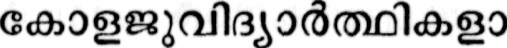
കോളജുവിദ്യാര്‍ത്ഥികളാ
